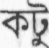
কটু
